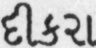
દીકરા
